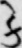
કે
